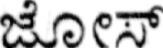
ಜೋಸ್
